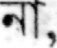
না,
